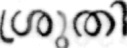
ശ്രുതി
